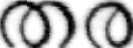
തര
